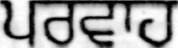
ਪਰਵਾਹ
